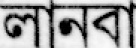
লানবা
